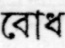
বোধ
